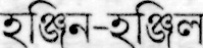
হঞ্জিন-হঞ্জিন
